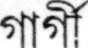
গার্গী
